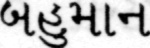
બહુમાન
